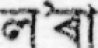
ল'ৰা
